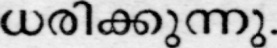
ധരിക്കുന്നു.
